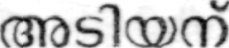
അടിയന്
